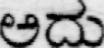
ಅದು
